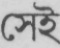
সেই
